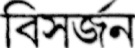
বিসর্জন
